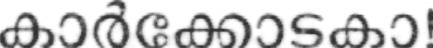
കാര്‍ക്കോടകാ!
